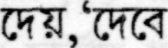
দেয়,‘দেবে
